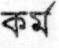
কর্ম
